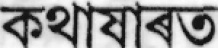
কথাষাৰত
